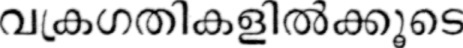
വക്രഗതികളില്‍ക്കൂടെ
